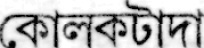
কোলকটাদা
